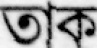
তাক
